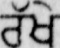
ਰੱਖੇ
